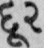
દૂર
